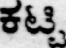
ಕಟ್ಟಿ
